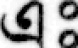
এঃ
